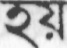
হয়
